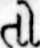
તો
